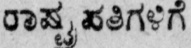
ರಾಷ್ಟ್ರಪತಿಗಳಿಗೆ
